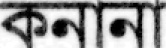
কনানা
